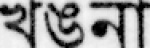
খঙনা
